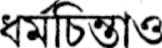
ধর্মচিন্তাও
